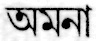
অমনা
